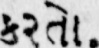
કરતો.
